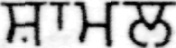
ਸ਼ਾਮਲ
